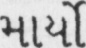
માર્યો
